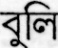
বুলি
